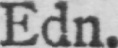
Edn.
